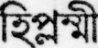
হিপ্লম্মী
